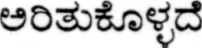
ಅರಿತುಕೊಳ್ಳದೆ
